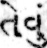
તેવું
